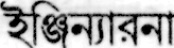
ইঞ্জিন্যারনা
